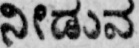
ನೀಡುವ
